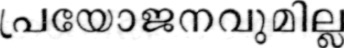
പ്രയോജനവുമില്ല
